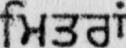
ਮਿਤਰਾਂ
